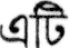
এটি
